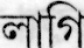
লাগি
